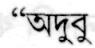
“অদুবু
